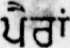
ਪੈਰਾਂ
